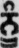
ਨੂੰ
